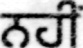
ਨਹੀਂ
